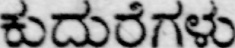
ಕುದುರೆಗಳು
